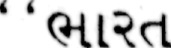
"ભારત
